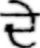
ਦੇ
